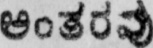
ಅಂತರವು
